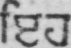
ਇਹ
